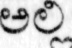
ಅಲ್ಲಿ
